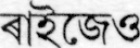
ৰাইজেও
